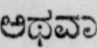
ಅಥವಾ
